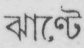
ঝাণ্টে
